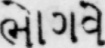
ભોગવે
